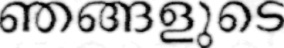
ഞങ്ങളുടെ
